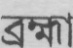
ব্ৰহ্মা
